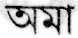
অমা
